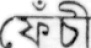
ফেঁচী
